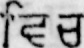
ਵਿਚ
